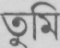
তুমি
